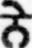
ਨੇ
